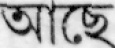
আছে
